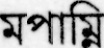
মপাম্নি
